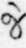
જે
